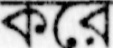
করে
